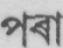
পৰা
